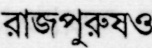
রাজপুরুষও
